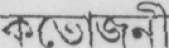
কতোজনী
